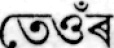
তেওঁৰ
